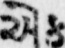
એક
